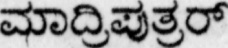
ಮಾದ್ರಿಪುತ್ರರ್
